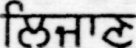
ਲਿਜਾਣ
